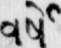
વર્ષે
